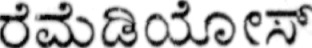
ರೆಮೆಡಿಯೋಸ್
